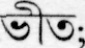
ভীত;
